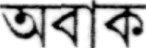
অবাক
